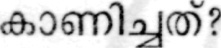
കാണിച്ചത്?
